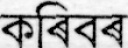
কৰিবৰ
